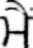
ਮੈਂ
